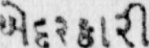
બેદરકારી
